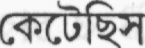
কেটেছিস
